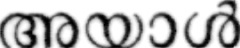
അയാള്‍
